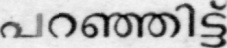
പറഞ്ഞിട്ട്
